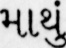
માથું
